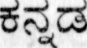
ಕನ್ನಡ
